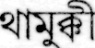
থামুক্কী
